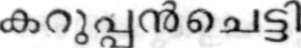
കറുപ്പന്‍ചെട്ടി
